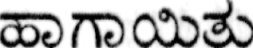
ಹಾಗಾಯಿತು
